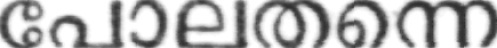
പോലതന്നെ
